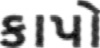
કાપો
